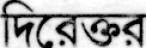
দিরেক্তর
